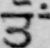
ਤੋਂ
